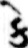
કે
